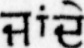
ਜਾਂਦੇ
